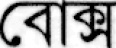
বোক্স
